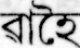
ৱাহৈ
